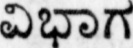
ವಿಭಾಗ
